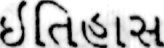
ઈતિહાસ
